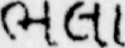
ભલા
